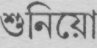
শুনিয়ো
